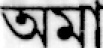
অমা
